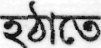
হঠাতে
